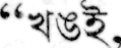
“খঙই,
